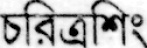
চরিত্রশিং
